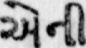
એની
